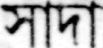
সাদা
